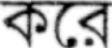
করে
